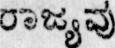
ರಾಜ್ಯವು
